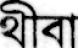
থীবা
